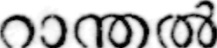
റാന്തല്‍
